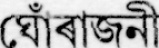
ঘোঁৰাজনী
